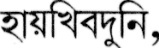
হায়খিবদুনি,
